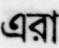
এরা
